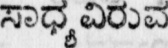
ಸಾಧ್ಯವಿರುವ
